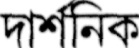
দার্শনিক
